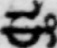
ಈ
